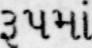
રૂપમાં
